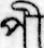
পী
